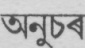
অনুচৰ
